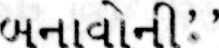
બનાવોની"
